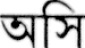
অসি
